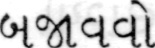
બજાવવો
